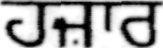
ਹਜ਼ਾਰ
